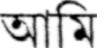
আমি
